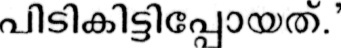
പിടികിട്ടിപ്പോയത്.’
